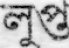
লুপ্ত
